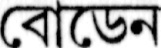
বোডেন
